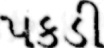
પકડી
